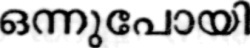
ഒന്നുപോയി
